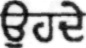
ਉਹਦੇ
